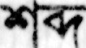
শব্দ
